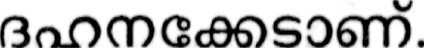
ദഹനക്കേടാണ്.
